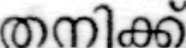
തനിക്ക്
